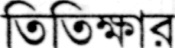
তিতিক্ষার
